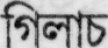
গিলাচ
